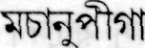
মচানুপীগা
